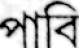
পাবি
